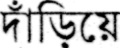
দাঁড়িয়ে
